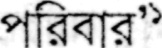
পরিবার’১
